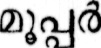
മൂപ്പര്‍
